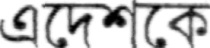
এদেশকে
